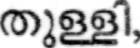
തുള്ളി,
